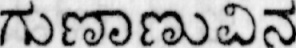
ಗುಣಾಣುವಿನ
